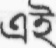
এই
